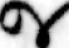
જ
